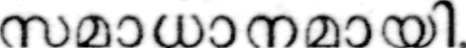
സമാധാനമായി.
